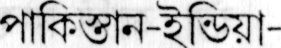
পাকিস্তান-ইন্ডিয়া-
